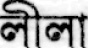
লীলা
